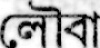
লৌবা
